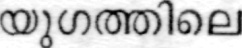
യുഗത്തിലെ
